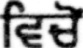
ਵਿਚੋਂ
